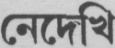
নেদেখি
